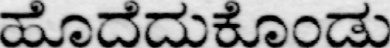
ಹೊದೆದುಕೊ೦ಡು
